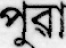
পুৱা
